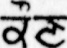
ਕੌਣ
